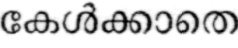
കേള്‍ക്കാതെ
